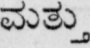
ಮತ್ತು
